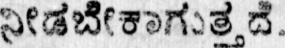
ನೀಡಬೇಕಾಗುತ್ತದೆ.
